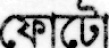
ফোটো
